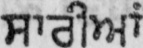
ਸਾਰੀਆਂ
